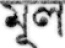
মূল
